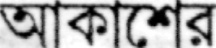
আকাশের
